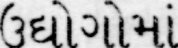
ઉદ્યોગોમાં
